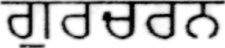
ਗੁਰਚਰਨ
